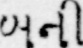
બની
